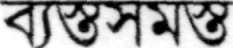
ব্যস্তসমস্ত
